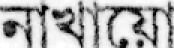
নাখায়ো
